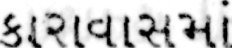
કારાવાસમાં
